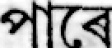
পাৰে
